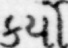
કર્યો
